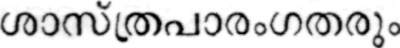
ശാസ്ത്രപാരംഗതരും
